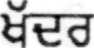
ਖੱਦਰ
